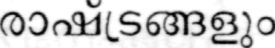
രാഷ്ട്രങ്ങളും
